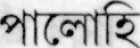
পালোহি
